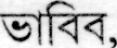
ভাবিব,
